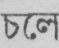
চলে
